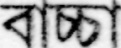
বাচ্চা
